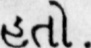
હતો.
